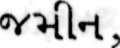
જમીન,
